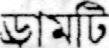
ড্রামটি
